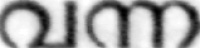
വന്ന
